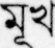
মূখ
